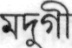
মদুগী
